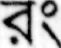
রং
